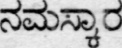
ನಮಸ್ಕಾರ
